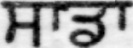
ਸਾਡਾ
